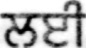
ਲਈ
